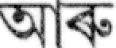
আৰু
